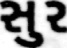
સુર
